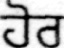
ਹੋਰ
